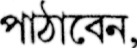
পাঠাবেন,
